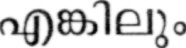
എങ്കിലും
